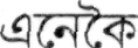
এনেকৈ
